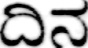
ದಿನ
